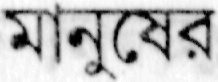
মানুষের
